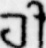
ਹੀ
